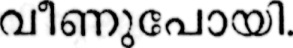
വീണുപോയി.
